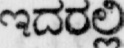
ಇದರಲ್ಲಿ
